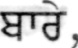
ਬਾਰੇ,
